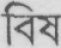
বিষ
